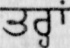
ਤਰ੍ਹਾਂ
